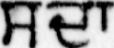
ਸਦਾ
